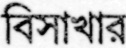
বিসাখার
